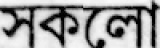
সকলো
